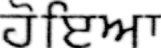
ਹੋਇਆ
